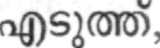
എടുത്ത്,
